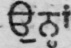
ਉਨ੍ਹਾਂ
